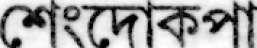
শেংদোকপা
